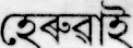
হেৰুৱাই
